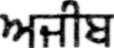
ਅਜੀਬ
